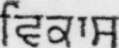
ਵਿਕਾਸ
